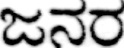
ಜನರ
